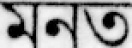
মনত
